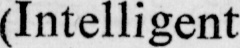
(Intelligent
